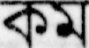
কম
